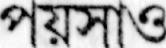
পয়সাও
